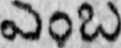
ಎಂಬ
